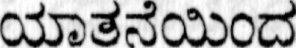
ಯಾತನೆಯಿಂದ
